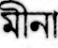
মীনা
